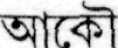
আকৌ
